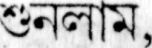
শুনলাম,
